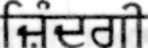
ਜ਼ਿੰਦਗੀ
